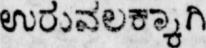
ಉರುವಲಕ್ಕಾಗಿ
